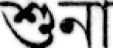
শুনা
